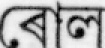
ৰোল
